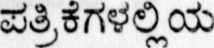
ಪತ್ರಿಕೆಗಳಲ್ಲಿಯ
